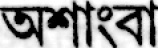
অশাংবা
